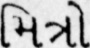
મિત્રો
